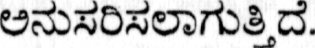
ಅನುಸರಿಸಲಾಗುತ್ತಿದೆ.
